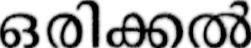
ഒരിക്കല്‍
